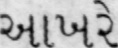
આખરે
